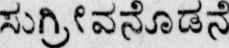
ಸುಗ್ರೀವನೊಡನೆ
